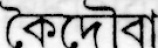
কৈদৌবা
